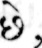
છે,
